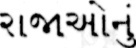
રાજાઓનું
